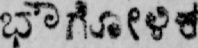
ಭೌಗೋಳಿಕ
